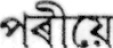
পৰীয়ে
